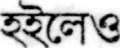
হইলেও
